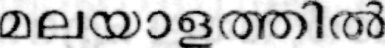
മലയാളത്തില്‍
